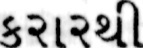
કરારથી
